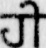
ਹੀ
